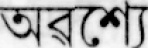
অৱশ্যে
